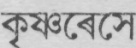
কৃষ্ণৰেসে
